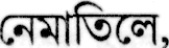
নেমাতিলে,
